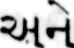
અને
